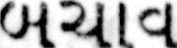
બચાવ
